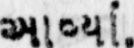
આવ્યાં.
